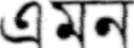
এমন
